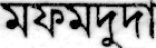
মফমদুদা
